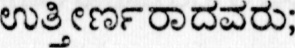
ಉತ್ತೀರ್ಣರಾದವರು;
